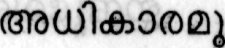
അധികാരമു
